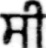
ਸੀ
